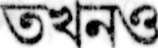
তখনও
